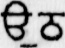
ਉਠ
